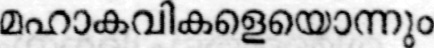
മഹാകവികളെയൊന്നും
